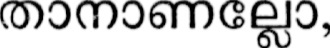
താനാണല്ലോ,
